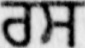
ਰਸ
